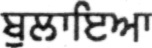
ਬੁਲਾਇਆ
